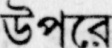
উপরে
